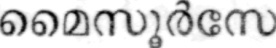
മൈസൂര്‍സേ
